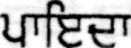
ਪਾਇਦਾ
